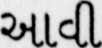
આવી
